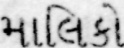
માલિકો
